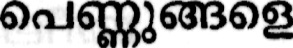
പെണ്ണുങ്ങളെ
